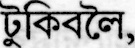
টুকিবলৈ,
